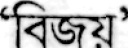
'বিজয়'
